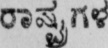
ರಾಷ್ಟ್ರಗಳ
